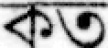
কত
